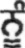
ਨੂੰ
